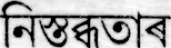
নিস্তব্ধতাৰ
